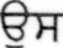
ਉਸ
